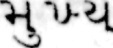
મુખ્ય
